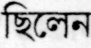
ছিলেন
